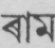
ৰাম
